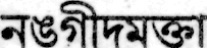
নঙগীদমক্তা
